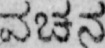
ವಚನ
